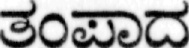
ತಂಪಾದ
